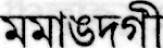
মমাঙদগী
